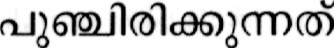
പുഞ്ചിരിക്കുന്നത്
